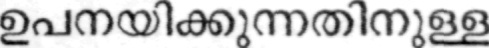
ഉപനയിക്കുന്നതിനുള്ള
